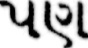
પણ
